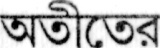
অতীতের
